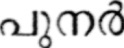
പുനര്‍
